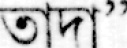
তাদা”
